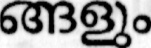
ങ്ങളും
